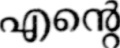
എന്റെ
